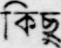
কিছু
